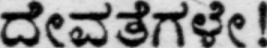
ದೇವತೆಗಳೇ!
